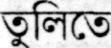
তুলিতে
